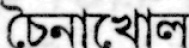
চৈনাখোল
